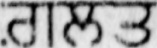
ਗ਼ਲਤ
